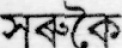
সৰুকৈ
